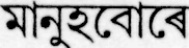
মানুহবোৰে
